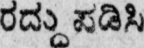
ರದ್ದುಪಡಿಸಿ
